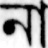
না
